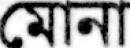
মোনা
